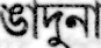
ঙাদুনা
